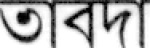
তাবদা
